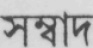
সম্বাদ
